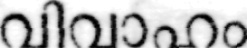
വിവാഹം
